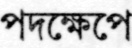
পদক্ষেপে
